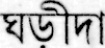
ঘড়ীদা
